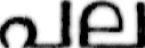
പല
